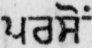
ਪਰਸੋਂ
